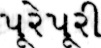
પૂરેપૂરી
